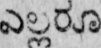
ಎಲ್ಲರೂ
